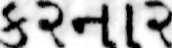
કરનાર
